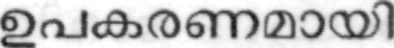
ഉപകരണമായി
